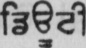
ਡਿਊਟੀ
